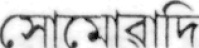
সোমোৱাদি
